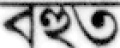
বহুত
